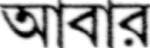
আবার
